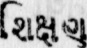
શિક્ષણ
